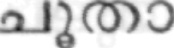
ചൂതാ
